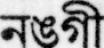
নঙগী
